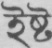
ইষ্ট
